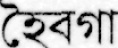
হৈবগা
